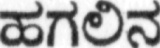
ಹಗಲಿನ
